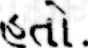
હતો.
